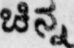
ಚಿನ್ನ
